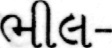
ભીલ-
